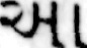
આ
